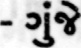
-ગુંજે
